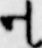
ન
